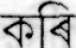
কৰি
